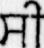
ਸੀ
